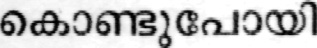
കൊണ്ടുപോയി
